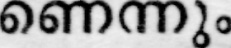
ണെന്നും
